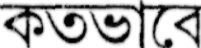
কতভাবে
